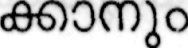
ക്കാനും
